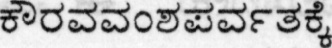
ಕೌರವವಂಶಪರ್ವತಕ್ಕೆ
